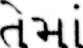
તેમાં
